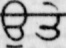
ਉਤੇ
